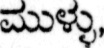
ಮುಳ್ಳು,
